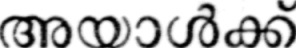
അയാള്‍ക്ക്
